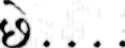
છે....
